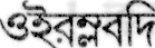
ওইরম্লবদি
